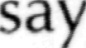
say
